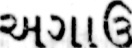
અગાઉ
